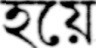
হয়ে
